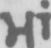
ਮਾਂ
